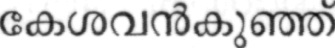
കേശവന്‍കുഞ്ഞ്
